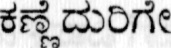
ಕಣ್ಣೆದುರಿಗೇ
